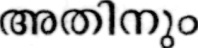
അതിനും
